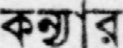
কন্যার
